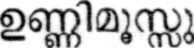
ഉണ്ണിമൂസ്സു
